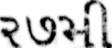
૨૭મી
